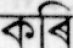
কৰি
